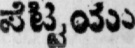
ಪೆಟ್ಟೆಯು
